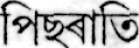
পিছৰাতি
